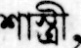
শাস্ত্রী,
